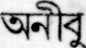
অনীবু
